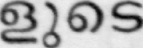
ളുടെ
